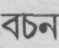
বচন
